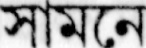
সামনে
